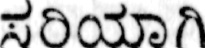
ಸರಿಯಾಗಿ
